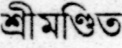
শ্রীমণ্ডিত
